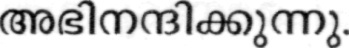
അഭിനന്ദിക്കുന്നു.
